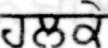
ਹਲਕੇ
